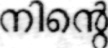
നിന്റെ
